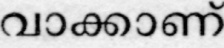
വാക്കാണ്
